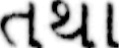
તથા
